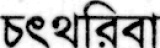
চৎথরিবা
